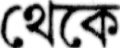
থেকে
